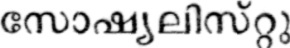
സോഷ്യലിസ്റ്റു
